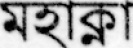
মহাক্না
